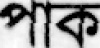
পাক
